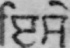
ਇਸੇ
